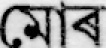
মোৰ
